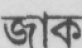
জাক
